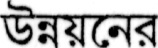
উন্নয়নের
